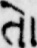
તો
